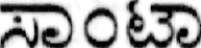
ಸಾಂಟಾ
